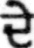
ਦੇ
